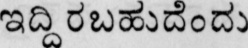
ಇದ್ದಿರಬಹುದೆಂದು
